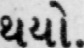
થયો.
